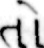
તો
